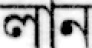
লান
